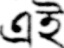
এই
